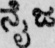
ನೈಜ
